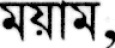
ময়াম,
